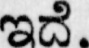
ಇದೆ.
